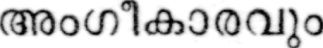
അംഗീകാരവും
